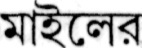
মাইলের
